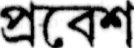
প্রবেশ
